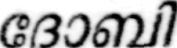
ദോബി
